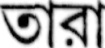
তারা
